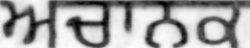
ਅਚਾਨਕ
